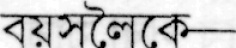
বয়সলৈকে-
